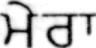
ਮੇਰਾ
